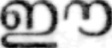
ഈ
